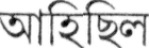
আহিছিল
